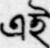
এই
